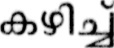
കഴിച്ച്
